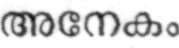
അനേകം
